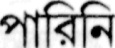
পারিনি
